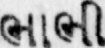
ભાભી
